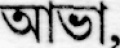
আভা,
